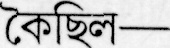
কৈছিল-
